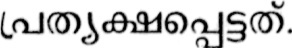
പ്രത്യക്ഷപ്പെട്ടത്.
